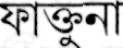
ফাক্তুনা
